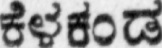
ಕೆಳಕಂಡ
